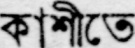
কাশীতে
